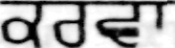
ਕਰਵਾ
